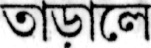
তাড়ালে
